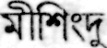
মীশিংদু
